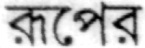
রূপের
